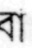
বা
